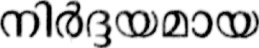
നിര്‍ദ്ദയമായ
